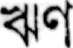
ঋণ
